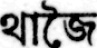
থাজৈ
